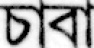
চাবা
